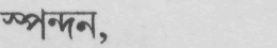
স্পন্দন,
